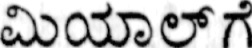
ಮಿಯಾಲ್ಗೆ
